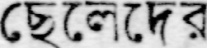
ছেলেদের
